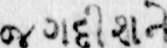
જગદીશને
